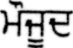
ਮੌਜੂਦ
